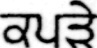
ਕਪੜੇ
